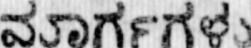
ಮಾರ್ಗಗಳು
